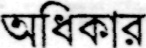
অধিকার
